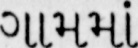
ગામમાં
